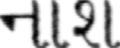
નાશ
